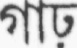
গাঢ়
